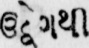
ઉદ્વેગથી
